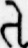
તે
